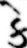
કે
